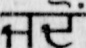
ਜਦੋਂ
